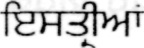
ਇਸਤ੍ਰੀਆਂ
